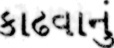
કાઢવાનું
